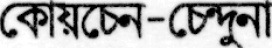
কোয়চেন-চেন্দুনা
